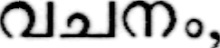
വചനം,
